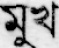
মুখ
